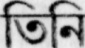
তিনি
